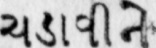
ચડાવીને
